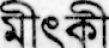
মীৎকী
